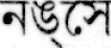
নঙসে
